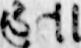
હતા
